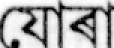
যোৰা
